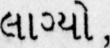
લાગ્યો,
